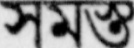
সমস্ত
